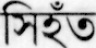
সিহঁত
